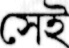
সেই
